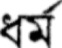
ধর্ম
